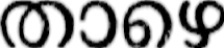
താഴെ
